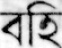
বহি
